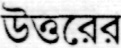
উত্তরের
